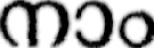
നാം
